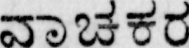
ವಾಚಕರ
